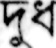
দুধ
